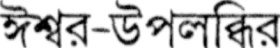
ঈশ্বর-উপলব্ধির
